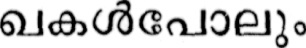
ഖകള്‍പോലും
